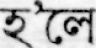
হ'লে
